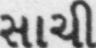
સાચી
